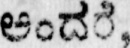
ಅಂದರೆ,
